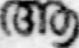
ആ
